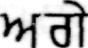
ਅਗੇ
